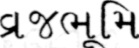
વ્રજભૂમિ
